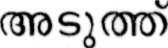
അടുത്ത്
